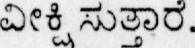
ವೀಕ್ಷಿಸುತ್ತಾರೆ.
